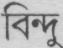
বিন্দু
